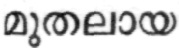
മുതലായ
